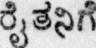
ರೈತನಿಗೆ
